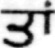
ਤਾਂ
